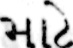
માટે
